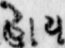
હોય
